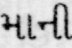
માની
